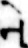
ને
